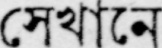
সেখানে
